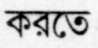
করতে
